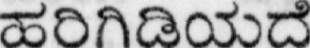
ಹರಿಗಿಡಿಯದೆ
